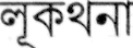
লূকথনা
